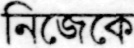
নিজেকে
